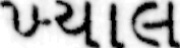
ખ્યાલ
